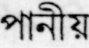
পানীয়
